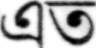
এত
